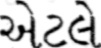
એટલે
